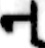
ન
